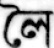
লৈ
